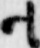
ન
